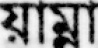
য়াম্না
